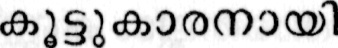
കൂട്ടുകാരനായി
